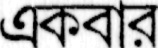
একবার
